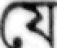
যে
